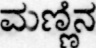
ಮಣ್ಣಿನ
